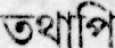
তথাপি
